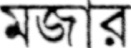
মজার
